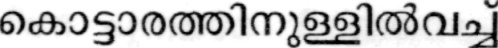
കൊട്ടാരത്തിനുള്ളില്‍വച്ച്
